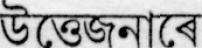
উত্তেজনাৰে
